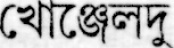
খোঞ্জেলদু
